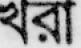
খরা
